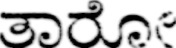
ತಾರೋ
